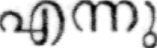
എന്നു
